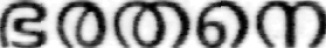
ഭരതനെ
